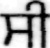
ਸੀ
